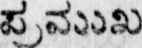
ಪ್ರಮುಖ
